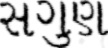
સગુણ
